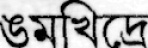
ঙমখিদ্রে
